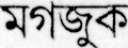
মগজুক
